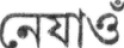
নেযাওঁ
